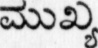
ಮುಖ್ಯ
